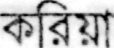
করিয়া
